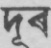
দূৰ
